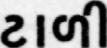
ટાળી
